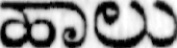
ಹಾಲು
